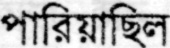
পারিয়াছিল
